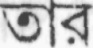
তার
